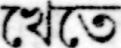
খেতে
